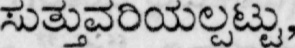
ಸುತ್ತುವರಿಯಲ್ಪಟ್ಟು,
